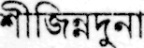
শীজিন্নদুনা
